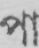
পা
